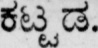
ಕಟ್ಟಡ.
